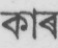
কাৰ
